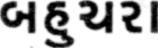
બહુચરા
